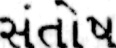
સંતોષ
